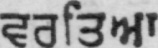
ਵਰਤਿਆ
